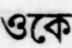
ওকে
